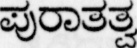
ಪುರಾತತ್ವ
